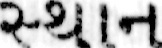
સ્થાન
